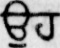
ਉਹ
